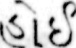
હોઈ
